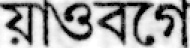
য়াওবগে
